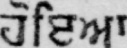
ਹੋਇਆ
